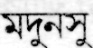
মদুনসু
